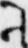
ને
